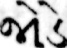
જોડે
